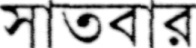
সাতবার
